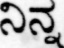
ನಿನ್ನ
